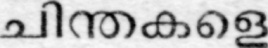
ചിന്തകളെ
